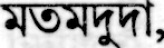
মতমদুদা,
